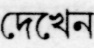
দেখেন
